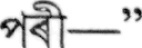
পৰী-"
